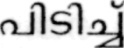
പിടിച്ച്
